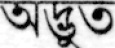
অদ্ভুত
